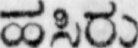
ಹಸಿರು
